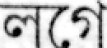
লগে
